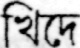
খিদে
